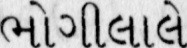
ભોગીલાલે
